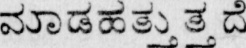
ಮಾಡಹತ್ತುತ್ತದೆ
